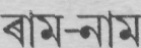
ৰাম-নাম
